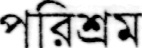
পরিশ্রম
